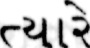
ત્યારે
